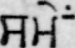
ਸਮੇਂ
